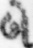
બે
